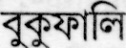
বুকুফালি
